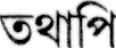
তথাপি
